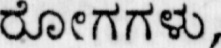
ರೋಗಗಳು,
